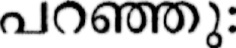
പറഞ്ഞു:
